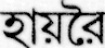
হায়রৈ
